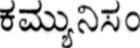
ಕಮ್ಯುನಿಸಂ
